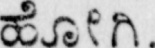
ಹೋಗಿ.
